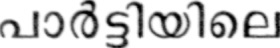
പാര്‍ട്ടിയിലെ
